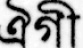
ঐগী
